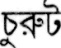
চুরুট
